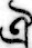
ঐ
